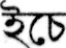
ইচে
